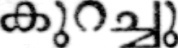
കുറച്ചു
